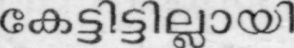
കേട്ടിട്ടില്ലായി
